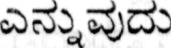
ಎನ್ನುವುದು
